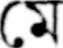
মে
